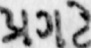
પ્રગટે
